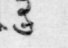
પૂરું
